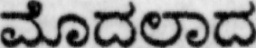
ಮೊದಲಾದ
